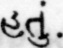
હતું.
